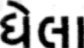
ઘેલા
